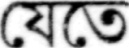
যেতে
